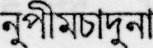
নুপীমচাদুনা
